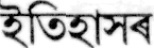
ইতিহাসৰ
